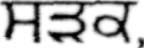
ਸੜਕ,
